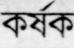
কর্ষক
